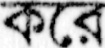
করে
